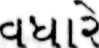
વધારે
